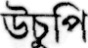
উচুপি
